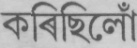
কৰিছিলোঁ
